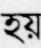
হয়
